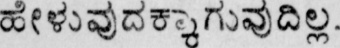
ಹೇಳುವುದಕ್ಕಾಗುವುದಿಲ್ಲ.
